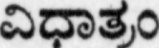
ವಿಧಾತ್ರಂ
